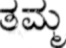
ತಮ್ಮ
